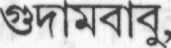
গুদামবাবু,
